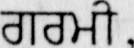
ਗਰਮੀ,
